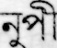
নুপী
